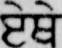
ਏਥੇ
